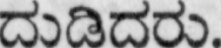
ದುಡಿದರು.
